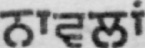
ਨਾਵਲਾਂ
